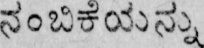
ನಂಬಿಕೆಯನ್ನು
